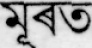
মূৰত
